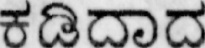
ಕಡಿದಾದ
